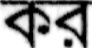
কর
